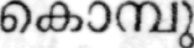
കൊമ്പു
